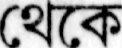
থেকে
